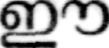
ഈ
